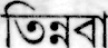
তিন্নবা
